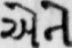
એને
